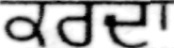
ਕਰਦਾ
